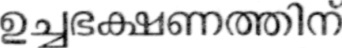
ഉച്ചഭക്ഷണത്തിന്
